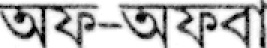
অফ-অফবা
